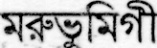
মরুভুমিগী
